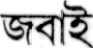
জবাই
